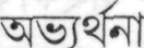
অভ্যৰ্থনা
